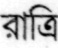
রাত্রি
